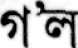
গ'ল
